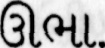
ઊભા.
